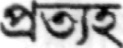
প্রত্যহ
